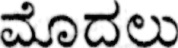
ಮೊದಲು
